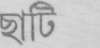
ছাটি
